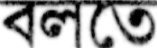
বলতে
